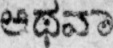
ಅಥವಾ
